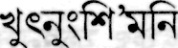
খুৎনুংশি’মনি
